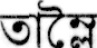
তাম্লৈ
